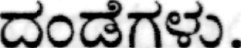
ದಂಡೆಗಳು.
